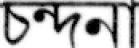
চন্দনা
